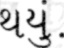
થયું.
